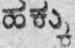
ಹಕ್ಕು
